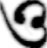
ও
